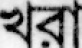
খরা
